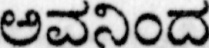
ಅವನಿಂದ
